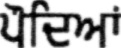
ਪੌਦਿਆਂ
